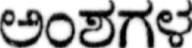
ಅಂಶಗಳ
